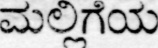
ಮಲ್ಲಿಗೆಯ
